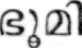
ഭൂമി
